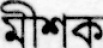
মীশক
